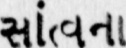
સાંત્વના
